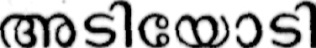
അടിയോടി
